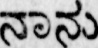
ನಾನು
